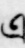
এ
